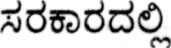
ಸರಕಾರದಲ್ಲಿ
